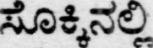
ಸೊಕ್ಕಿನಲ್ಲಿ
